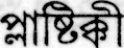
প্লাষ্টিক্কী
